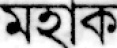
মহাক
